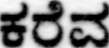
ಕರೆವ
